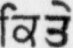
ਕਿਤੇ
